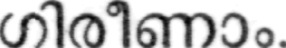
ഗിരീണാം.
